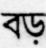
বড়
